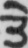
ਤੇ
